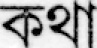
কথা
